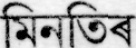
মিনতিৰ
